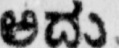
ಅದು
